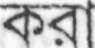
করা
